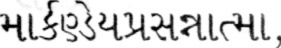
માર્કણ્ડેપ્રસન્નત્મા,
